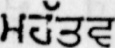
ਮਹੱਤਵ
